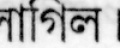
লাগিল।
